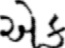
એક
